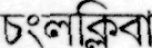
চংলক্লিবা
